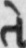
તે
